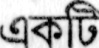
একটি
